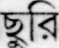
ছুরি
